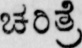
ಚರಿತ್ರೆ
